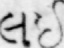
લઈ
